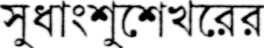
সুধাংশুশেখরের
